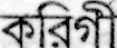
করিগী
